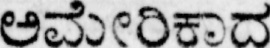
ಅಮೇರಿಕಾದ
